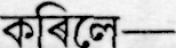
কৰিলে-
